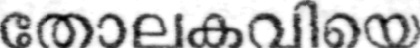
തോലകവിയെ
